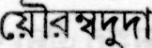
য়ৌরম্বদুদা
